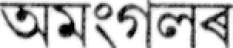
অমংগলৰ
